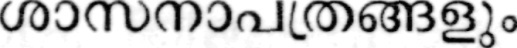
ശാസനാപത്രങ്ങളും
